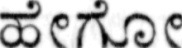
ಹೇಗೋ
